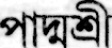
পাদ্মশ্রী
